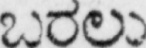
ಬರಲು
